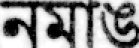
নমাঙ
